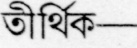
তীর্থিক–
